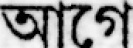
আগে
